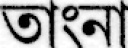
তাংনা
